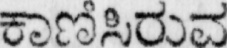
ಕಾಣಿಸಿರುವ
